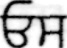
ਓਸ
